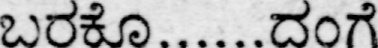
ಬರಕೊ......ದ೦ಗೆ
